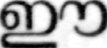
ഈ
